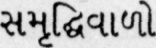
સમૃદ્ધિવાળો
